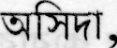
অসিদা,
